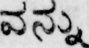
ವನ್ನು
